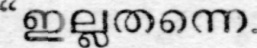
"ഇല്ലതന്നെ.
